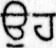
ਉਹ
